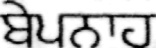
ਬੇਪਨਾਹ
